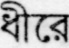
ধীরে
